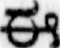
ಈ
